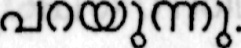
പറയുന്നു.
